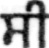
ਸੀ
